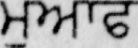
ਮੁਆਫ
